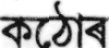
কঠোৰ
